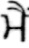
ਮੈਂ
